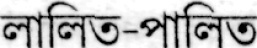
লালিত-পালিত
